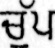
ਚੁੱਪ
